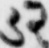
ડર
